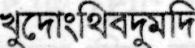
খুদোংথিবদুমদি
